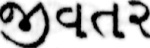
જીવતર
